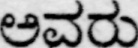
ಅವರು
